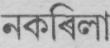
নকৰিলা
